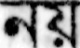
নয়
